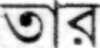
তার
